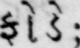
ફોડે;
